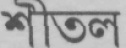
শীতল
